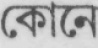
কোনে
